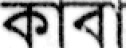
কাবা
